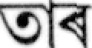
তাৰ
